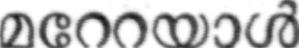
മറ്റേയാള്‍
